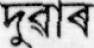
দুৱাৰ
